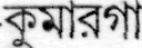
কুমারগা
